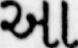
આ
